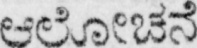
ಆಲೋಚನೆ
